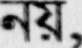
নয়,
